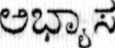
ಅಭ್ಯಾಸ
